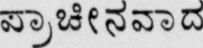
ಪ್ರಾಚೀನವಾದ
